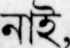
নাই,
